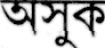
অসুক
